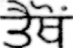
ਤੈਥੋਂ
